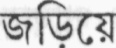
জড়িয়ে
